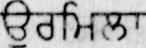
ਉਰਮਿਲਾ
